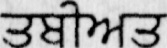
ਤਬੀਅਤ
